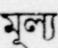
মূল্য
